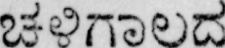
ಚಳಿಗಾಲದ
